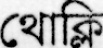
থোক্লি
